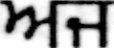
ਅਜ
